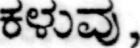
ಕಳುವು,
